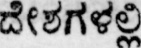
ದೇಶಗಳಲ್ಲಿ
